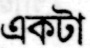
একটা
